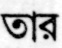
তার
